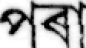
পৰা
